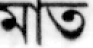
মাত
